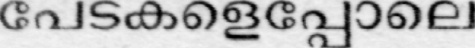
പേടകളെപ്പോലെ
